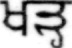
ਖੜ੍ਹ
